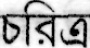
চরিত্র
